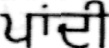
ਪਾਂਦੀ
